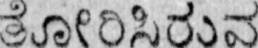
ತೋರಿಸಿರುವ
